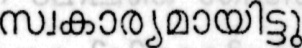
സ്വകാര്യമായിട്ടു
